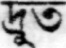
দ্রুত
